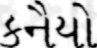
કનૈયો
